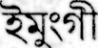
ইমুংগী
